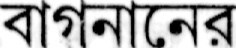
বাগনানের
